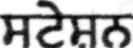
ਸਟੇਸ਼ਨ
